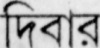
দিবার
